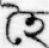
হৈ
